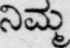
ನಿಮ್ಮ
